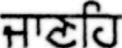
ਜਾਣਹਿ
